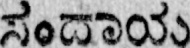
ಸಂದಾಯ
